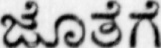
ಜೊತೆಗೆ
